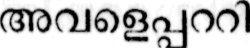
അവളെപ്പററി
